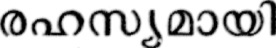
രഹസ്യമായി
